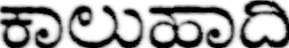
ಕಾಲುಹಾದಿ
